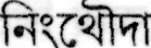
নিংথৌদা
